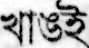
খাঙই
